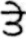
ਤੇ
